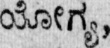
ಯೋಗ್ಯ,
